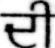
ਦੀ
